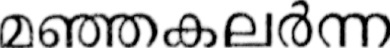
മഞ്ഞകലര്‍ന്ന
